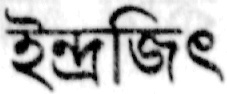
ইন্দ্রজিৎ
